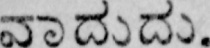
ವಾದುದು.
